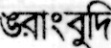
ঙরাংবুদি
